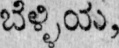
ಬೆಳ್ಳಿಯ,
